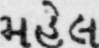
મહેલ
